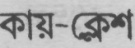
কায়-ক্লেশ
